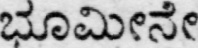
ಭೂಮೀನೇ
